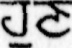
ਹੁਣ
